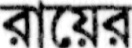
রায়ের
